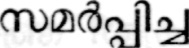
സമര്‍പ്പിച്ച
